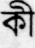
কী
